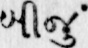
બીજું
